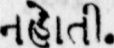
નહોતી.
